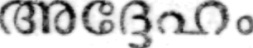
അദ്ദേഹം
